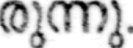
രുന്നു.
